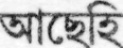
আছেহি
